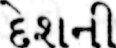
દેશની
